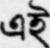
এই
